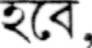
হবে,
